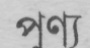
পূণ্য
